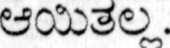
ಆಯಿತಲ್ಲ.
